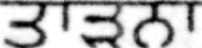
ਤਾੜਨਾ
